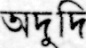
অদুদি
